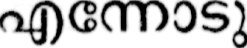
എന്നോടു
